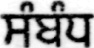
ਸੰਬੰਧ
